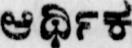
ಆರ್ಥಿಕ
